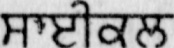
ਸਾਈਕਲ
